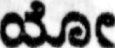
ಯೋ
